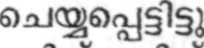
ചെയ്യപ്പെട്ടിട്ടു
